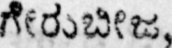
ಗೇರುಬೀಜ,
